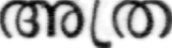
അത്ര
